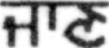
ਜਾਣ
